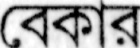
বেকার
